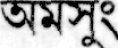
অমসুং
